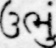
ઉભું
